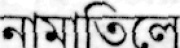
নামাতিলে
